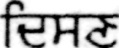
ਦਿਸਣ
